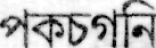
পকচগনি
